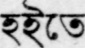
হইতে
